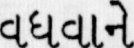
વધવાને
